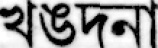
খঙদনা
